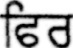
ਫਿਰ
